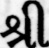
શ્રી
